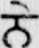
ਨੇ
